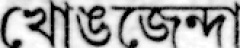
খোঙজেন্দা
